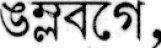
ঙম্লবগে,
